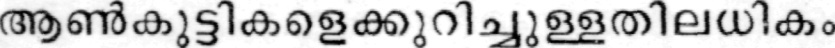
ആണ്‍കുട്ടികളെക്കുറിച്ചുള്ളതിലധികം
